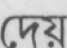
দেয়
